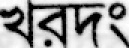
খরদং
